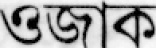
ওজাক
